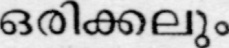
ഒരിക്കലും
